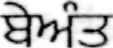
ਬੇਅੰਤ
